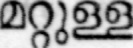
മറ്റുള്ള
